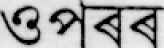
ওপৰৰ
